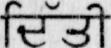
ਦਿੱਤੀ
